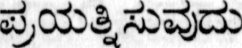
ಪ್ರಯತ್ನಿಸುವುದು
